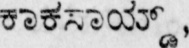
ಕಾಕಸಾಯ್ಡ್,
